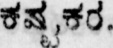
ಕಷ್ಟಕರ.
